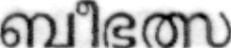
ബീഭത്സ
